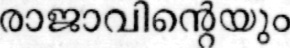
രാജാവിന്റെയും
